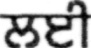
ਲਈ
